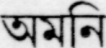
অমনি
